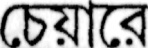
চেয়ারে
